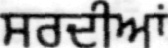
ਸਰਦੀਆਂ
